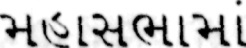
મહાસભામાં
